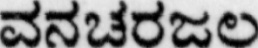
ವನಚರಜಲ
